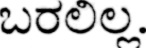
ಬರಲಿಲ್ಲ.
